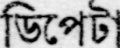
ডিপেটা
